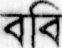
ববি
